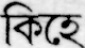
কিহে
